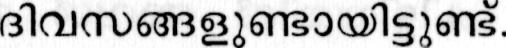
ദിവസങ്ങളുണ്ടായിട്ടുണ്ട്.
